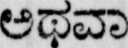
ಅಥವಾ
